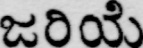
ಜರಿಯೆ
